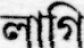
লাগি
